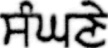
ਸੰਘਣੇ
